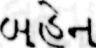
બહેન
